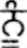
ਨੂੰ
